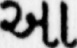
આ
